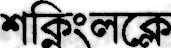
শক্নিংলক্লে
